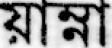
য়াম্না
